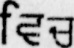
ਵਿਚ
